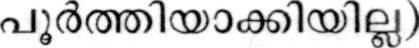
പൂര്‍ത്തിയാക്കിയില്ല)
